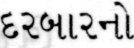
દરબારનો
